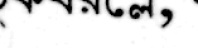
তুকথরম্লে,
